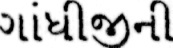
ગાંધીજીની
